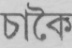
চাকৈ
